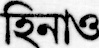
হিনাও
